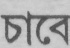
চাবে
